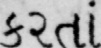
કરતાં
